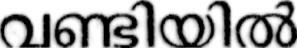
വണ്ടിയില്‍
